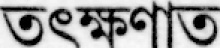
তৎক্ষণাত
